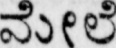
ಮೇಲೆ
